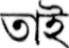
তাই
